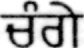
ਚੰਗੇ
